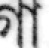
গা
